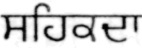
ਸਹਿਕਦਾ
